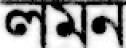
লমন
